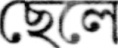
ছেলে
